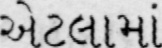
એટલામાં
